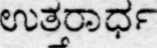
ಉತ್ತರಾರ್ಧ
